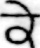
ਕੇ
